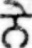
ਨੇ
